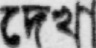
দেখা
